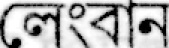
লেংবান
